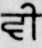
ਵੀ
